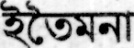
ইতৈমনা
